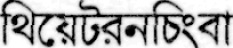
থিয়েটরনচিংবা
